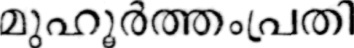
മുഹൂര്‍ത്തംപ്രതി
